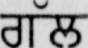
ਗੱਲ
